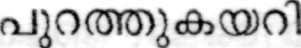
പുറത്തുകയറി
